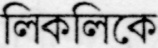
লিকলিকে
